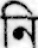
নি
